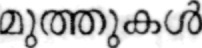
മുത്തുകള്‍
